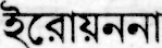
ইরোয়ননা
